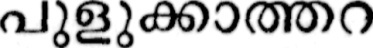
പുളുക്കാത്തറ
